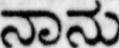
ನಾನು
